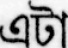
এটা
